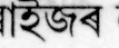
ৰাইজৰ
